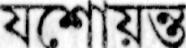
যশোয়ন্ত
